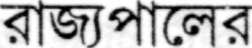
রাজ্যপালের
